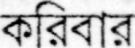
করিবার
